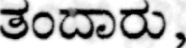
ತಂದಾರು,
